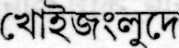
খোইজংলুদে
